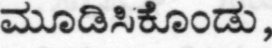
ಮೂಡಿಸಿಕೊಂಡು,
